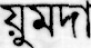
য়ুমদা
